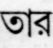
তার
